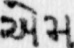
એમ
